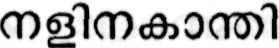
നളിനകാന്തി
